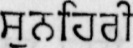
ਸੁਨਹਿਰੀ
